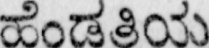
ಹೆಂಡತಿಯ
